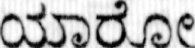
ಯಾರೋ
